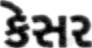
કેસર
